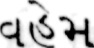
વહેમ
